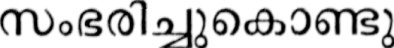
സംഭരിച്ചുകൊണ്ടു
